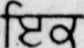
ਇਕ
